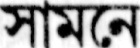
সামনে
